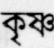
কৃষ্ণ
